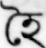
হৈ
